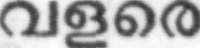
വളരെ
